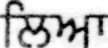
ਲਿਆ
